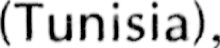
(Tunisia),
